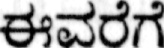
ಈವರೆಗೆ
